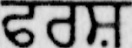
ਫਰਸ਼
